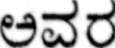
ಅವರ
